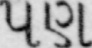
પણ
